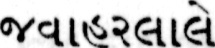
જવાહરલાલે
